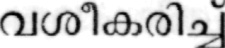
വശീകരിച്ച്
